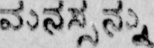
ಮನಸ್ಸನ್ನು
